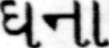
ધના
